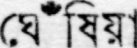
ঘেঁষিয়া
